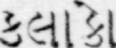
કલાકો
